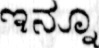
ಇನ್ನೂ
